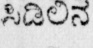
ಸಿಡಿಲಿನ
